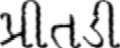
પ્રીતડી
